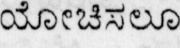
ಯೋಚಿಸಲೂ
